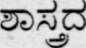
ಶಾಸ್ತ್ರದ
